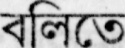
বলিতে
